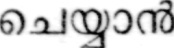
ചെയ്യാന്‍
